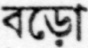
বড়ো
